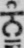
ਨੂੰ
